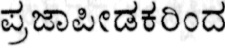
ಪ್ರಜಾಪೀಡಕರಿಂದ
